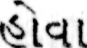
હોવા
